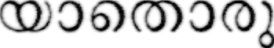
യാതൊരു
